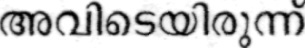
അവിടെയിരുന്ന്
